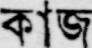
কাজ
